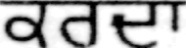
ਕਰਦਾ
